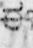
ಈ
